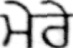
ਮੇਰੇ
